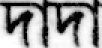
দাদা
